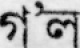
গ'ল
